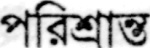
পরিশ্রান্ত
